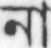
না
